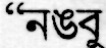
“নঙবু
